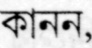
কানন,
